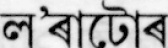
ল'ৰাটোৰ
